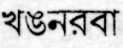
খঙনরবা
